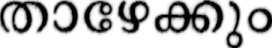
താഴേക്കും
